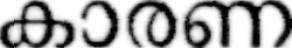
കാരണ
